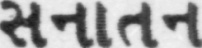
સનાતન
